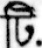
টি.
